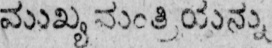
ಮುಖ್ಯಮಂತ್ರಿಯನ್ನು
